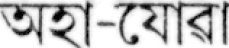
অহা-যোৱা
